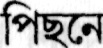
পিছনে
